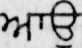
ਆਉ
